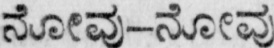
ನೋವು-ನೋವು
